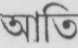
আতি
